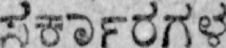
ಸರ್ಕಾರಗಳ
